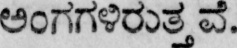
ಅಂಗಗಳಿರುತ್ತವೆ.
